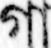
গা
